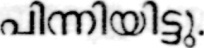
പിന്നിയിട്ടു.
